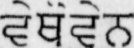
ਵੇਥੋਵੇਨ
